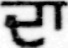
ਦਾ
